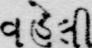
વહેલી
